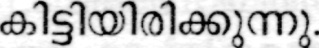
കിട്ടിയിരിക്കുന്നു.
